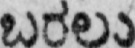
ಬರಲು
